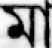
মা
